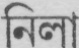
নিলা
